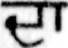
ਦਾ
